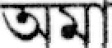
অমা
